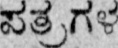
ಪತ್ರಗಳ
